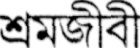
শ্রমজীবী
